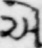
એ
